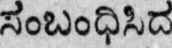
ಸಂಬಂಧಿಸಿದ
